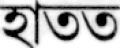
হাতত
